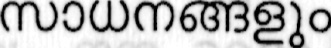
സാധനങ്ങളും
